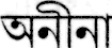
অনীনা
